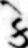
કે
